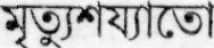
মৃত্যুশয্যাতো
